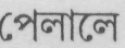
পেলালে
